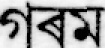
গৰম
